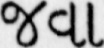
જવા
